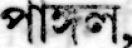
পাঙ্গল,
